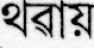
থৱায়
